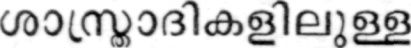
ശാസ്ത്രാദികളിലുള്ള
